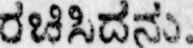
ರಚಿಸಿದನು.
